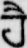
ਹੈ
